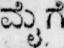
ಮೈಗೆ
